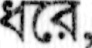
ধরে,
